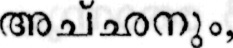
അച്ഛനും,
